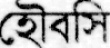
হৌবসি
